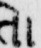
તો
